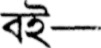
বই-
